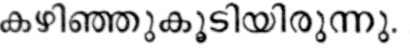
കഴിഞ്ഞുകൂടിയിരുന്നു.
